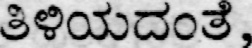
ತಿಳಿಯದಂತೆ,
